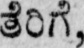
ತೆರಿಗೆ,
